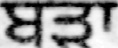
ਬੜਾ
